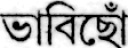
ভাবিছোঁ
